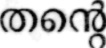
തന്റെ
